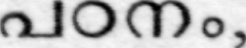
പഠനം,
